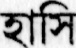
হাসি
